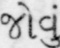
જોવું
